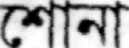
শোনা
